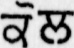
ਕੋਲ
